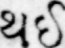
થઈ
